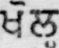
ਖੋਲ੍ਹ
